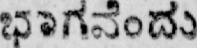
ಭಾಗವೆಂದು
